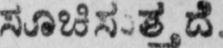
ಸೂಚಿಸುತ್ತದೆ.
